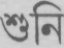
শুনি
